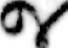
જ
